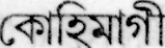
কোহিমাগী
